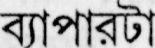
ব্যাপারটা
